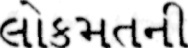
લોકમતની
